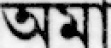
অমা
